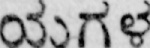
ಯಗಳ
